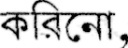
করিনো,
